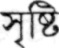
সৃষ্টি
